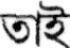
তাই
